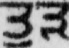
ਤੁੜ
